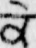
ਕੇ
